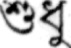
শুধু
